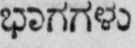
ಭಾಗಗಳು
